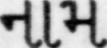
નામ
